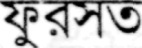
ফুরসত
